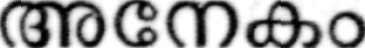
അനേകം
